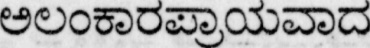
ಅಲಂಕಾರಪ್ರಾಯವಾದ
